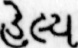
હેલ્ય
